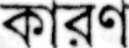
কারণ
